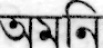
অমনি
